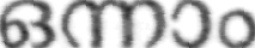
ഒന്നാം
